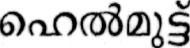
ഹെല്‍മുട്ട്
